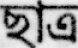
ছাত্র
